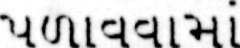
પળાવવામાં
